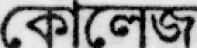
কোলেজ
